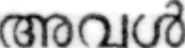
അവള്‍
